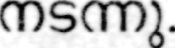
നടന്നു.
